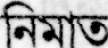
নিমাত
